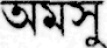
অমসু
